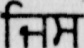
ਜਿਸ
